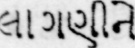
લાગણીને
